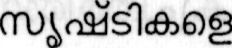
സൃഷ്ടികളെ
